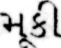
મૂકી
